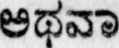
ಅಥವಾ
